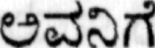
ಅವನಿಗೆ
